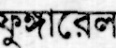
ফুঙ্গারেল
